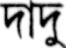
দাদু
